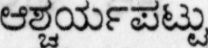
ಆಶ್ಚರ್ಯಪಟ್ಟು
